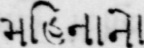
મહિનાનો
